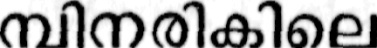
മ്പിനരികിലെ
